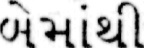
બેમાંથી
